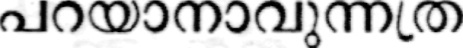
പറയാനാവുന്നത്ര
